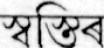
স্বস্তিৰ
